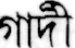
গাদী
